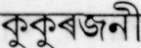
কুকুৰজনী
